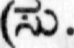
(ಸು.
